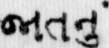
જાતનું
